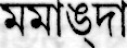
মমাঙদা
